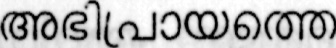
അഭിപ്രായത്തെ
